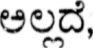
ಅಲ್ಲದೆ,
